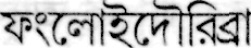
ফংলোইদৌরিব্রা
